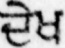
ਦੇਖ
